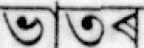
ভাতৰ
